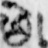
છો
